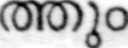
ത്തും
